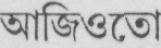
আজিওতো
